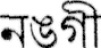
নঙগী
